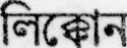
লিক্কোন
